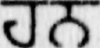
ਹਨ
